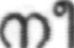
നീ
